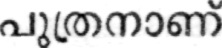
പുത്രനാണ്
